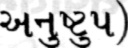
અનુષ્ટુપ)
